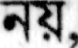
নয়,
